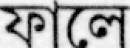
ফালে
